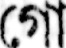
গো
